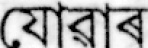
যোৱাৰ
